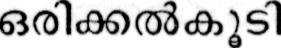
ഒരിക്കല്‍കൂടി
